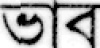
ভাব
